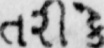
તરીકે
